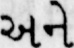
અને
